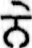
ਨੇ
